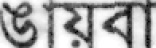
ঙায়বা
